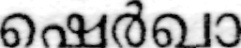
ഷെര്‍ഖാ
